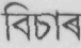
বিচাৰ
